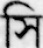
সি
